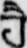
ਹੈ
